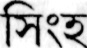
সিংহ
